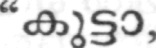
"കുട്ടാ,
